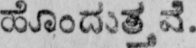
ಹೊಂದುತ್ತವೆ.
